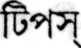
টিপস্
